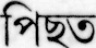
পিছত
